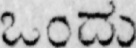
ಒಂದು
